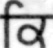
ਕਿ
